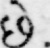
છે.
